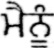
ਮੈਨੂੰ
